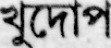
খুদোপ
